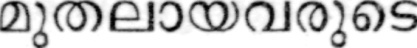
മുതലായവരുടെ
